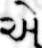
એ
